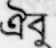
ঐবু
